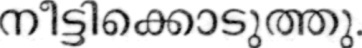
നീട്ടിക്കൊടുത്തു.
